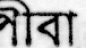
পীবা
